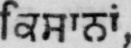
ਕਿਸਾਨਾਂ,
